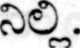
ನಿಲ್ಲಿ.
